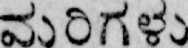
ಮರಿಗಳು
